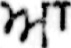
ਆ
